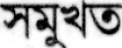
সমুখত
